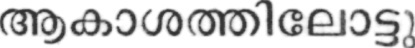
ആകാശത്തിലോട്ടു
